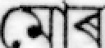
মোৰ
